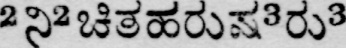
2ನಿ2ಚಿತಹರುಷ3ರು3
